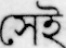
সেই
